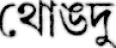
থোংদু
